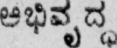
ಅಭಿವೃದ್ಧ
